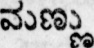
ಮಣ್ಣು
